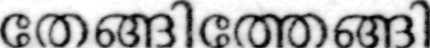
തേങ്ങിത്തേങ്ങി
